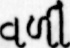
વળી
